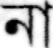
না
